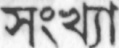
সংখ্যা
